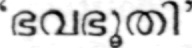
‘ഭവഭൂതി’
